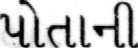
પોતાની
